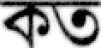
কত
